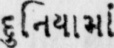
દુનિયામાં
